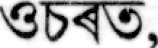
ওচৰত,
